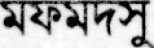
মফমদসু
